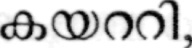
കയററി,
